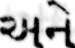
અને
